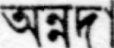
অন্নদা
